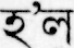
হ'ল
